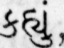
કહ્યું,
